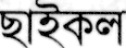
ছাইকল
